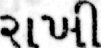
રાખી
